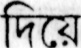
দিয়ে
